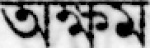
অক্ষম
